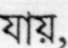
যায়,
